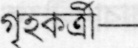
গহকর্ত্রী–
